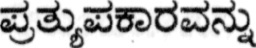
ಪ್ರತ್ಯುಪಕಾರವನ್ನು
